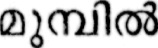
മുമ്പില്‍
